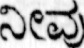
ನೀವು
